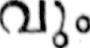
വും
